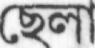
ছেলা
